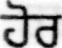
ਹੋਰ
